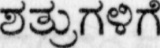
ಶತ್ರುಗಳಿಗೆ
